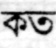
কত
